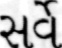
સર્વે
